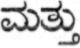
ಮತ್ತು
